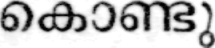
കൊണ്ടു
